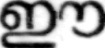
ഈ
